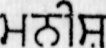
ਮਨੀਸ਼
